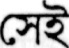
সেই
